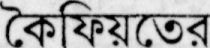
কৈফিয়তের
